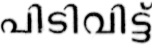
പിടിവിട്ട്
